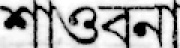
শাওবনা
